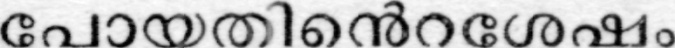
പോയതിന്റെശേഷം
